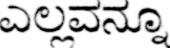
ಎಲ್ಲವನ್ನೂ
